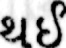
થઈ
